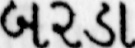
બરડા
